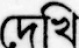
দেখি
